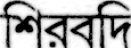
শিরবদি
